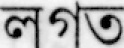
লগত
